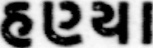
હણ્યા
